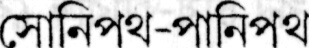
সোনিপথ-পানিপথ
